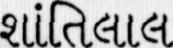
શાંતિલાલ
